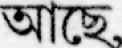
আছে,
